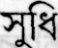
সুধি
